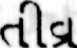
તીવ્ર
